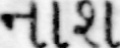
નાશ
